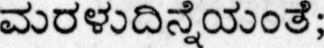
ಮರಳುದಿನ್ನೆಯಂತೆ;
